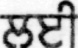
ਲਈ
